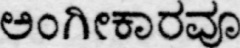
ಅಂಗೀಕಾರವೂ
